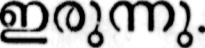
ഇരുന്നു.
